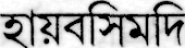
হায়বসিমদি
